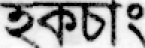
হকচাং
